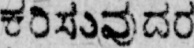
ಕರಿಸುವುದರ
